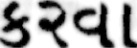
કરવા
